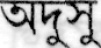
অদুসু
